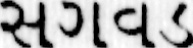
સગવડ
